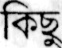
কিছু
